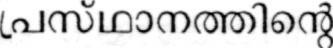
പ്രസ്ഥാനത്തിന്റെ
